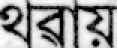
থৱায়
